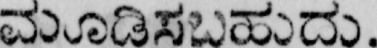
ಮೂಡಿಸಬಹುದು.
